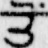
ਤੋਂ
